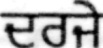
ਦਰਜੇ
